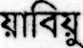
য়াবিয়ু
